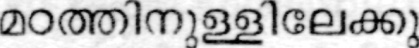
മഠത്തിനുള്ളിലേക്കു
